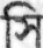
সি
